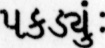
પકડ્યું:
